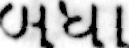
બધા
